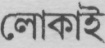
লোকাই
